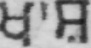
ਖਾਸ਼
